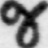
જ
